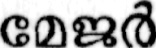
മേജര്‍
